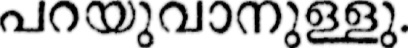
പറയുവാനുള്ളു.
